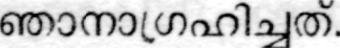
ഞാനാഗ്രഹിച്ചത്.
